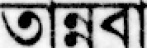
তান্নবা
